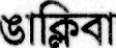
ঙাক্লিবা
